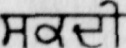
ਸਕਦੀ
